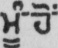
ਮੂੰਹੋਂ
